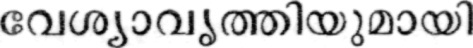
വേശ്യാവൃത്തിയുമായി
